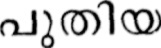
പുതിയ
